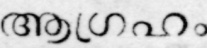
ആഗ്രഹം
